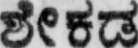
ಶೇಕಡ
